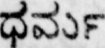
ಧರ್ಮ
